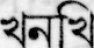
খনখি
